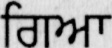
ਗਿਆ
